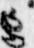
હું
